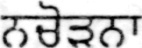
ਨਚੋੜਨਾ
